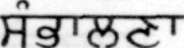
ਸੰਭਾਲਣਾ
